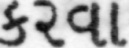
કરવા
